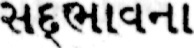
સદ્ભાવના
